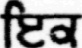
ਇਕ
